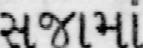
સજામાં
